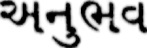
અનુભવ
